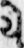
યે
